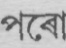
পৰো
